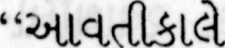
"આવતીકાલે
